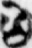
છે
